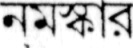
নমস্কার
